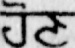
ਹੋਣ
